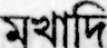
মখাদি
